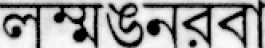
লম্মঙনরবা
